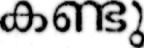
കണ്ടു
